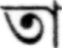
তা
